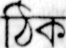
ঠিক
